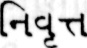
નિવૃત્ત
